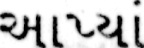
આપ્યાં
